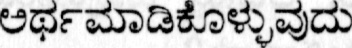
ಅರ್ಥಮಾಡಿಕೊಳ್ಳುವುದು
